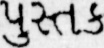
પુસ્તક
